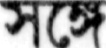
সঙ্গে
